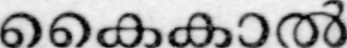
കൈകാല്‍
